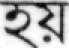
হয়
